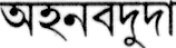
অহনবদুদা
